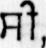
ਸੀ,
